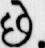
છે.
